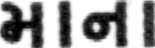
માના
